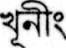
খূনীং
